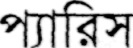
প্যারিস
